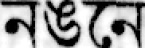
নঙনে
